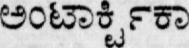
ಅಂಟಾರ್ಕ್ಟಿಕಾ
